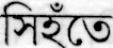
সিহঁতে
